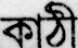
কাঠী
